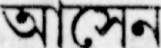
আসেন
